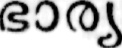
ഭാര്യ
